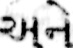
અને
